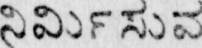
ನಿರ್ಮಿಸುವ
